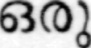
ഒരു
